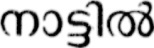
നാട്ടില്‍
